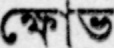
ক্ষোভ
